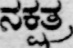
ನಕ್ಷತ್ರ
